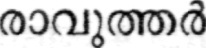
രാവുത്തര്‍
